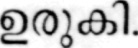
ഉരുകി.
